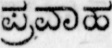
ಪ್ರವಾಹ
